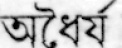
অধৈর্য
